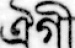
ঐগী
